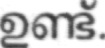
ഉണ്ട്.
